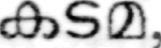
കടമ,
